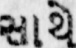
સાથે
